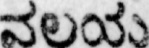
ವಲಯ
